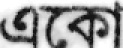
একো
